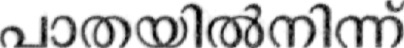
പാതയില്‍നിന്ന്
